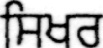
ਸਿਖਰ
